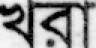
খরা
